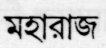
মহারাজ
